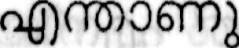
എന്താണു
